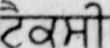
ਟੈਕਸੀ
